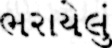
ભરાયેલું
